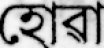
হোৱা
